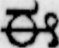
ಈ
